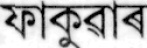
ফাকুৱাৰ
